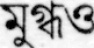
মুগ্ধও
